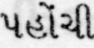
પહોંચી
